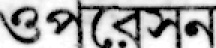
ওপরেসন
